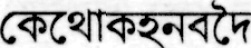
কেথোকহনবদৈ
